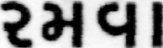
રમવા
